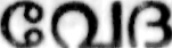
വേദ
